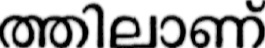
ത്തിലാണ്
